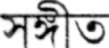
সঙ্গীত
